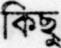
কিছু
